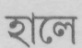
হালে
